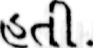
હતી.
